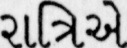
રાત્રિએ
